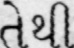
તેથી
